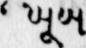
'ખુબ
